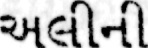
અલીની
